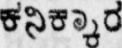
ಕನಿಕ್ಕಾರ
